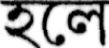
হলে
